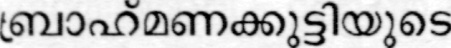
ബ്രാഹ്മണക്കുട്ടിയുടെ
